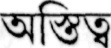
অস্তিত্ব
